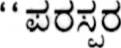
"ಪರಸ್ಪರ
